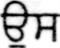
ਉਸ
